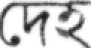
দেহ
